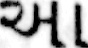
આ
